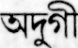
অদুগী
